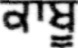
ਕਾਬੂ
